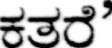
ಕತರೆ'
